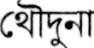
থৌদুনা
